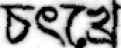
চৎখ্রে
